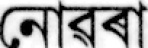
নোৱৰা
